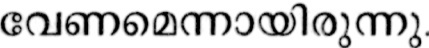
വേണമെന്നായിരുന്നു.
